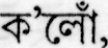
ক'লোঁ,
